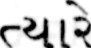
ત્યારે
